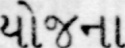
યોજના
